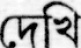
দেখি
